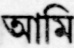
আমি
